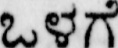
ಒಳಗೆ
